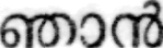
ഞാന്‍
